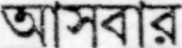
আসবার
